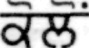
ਕੋਲੋਂ
